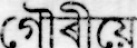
গৌৰীয়ে
